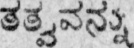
ತತ್ವವನ್ನು
